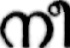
നീ
